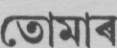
তোমাৰ
